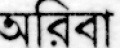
অরিবা
